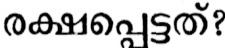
രക്ഷപ്പെട്ടത്?
